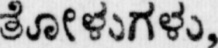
ತೋಳುಗಳು,
